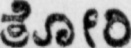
ತೋರಿ
